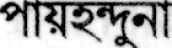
পায়হন্দুনা
